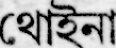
থোইনা
